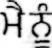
ਮੈਨੂੰ
